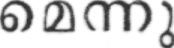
മെന്നു
